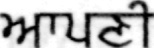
ਆਪਣੀ
